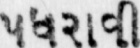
પધરાવી
